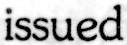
issued
